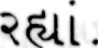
રહ્યાં.
